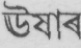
ঊষাৰ
